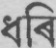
ধৰি
